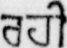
ਰਹੀ
